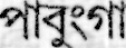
পাবুংগা
